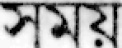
সময়
